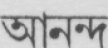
আনন্দ
